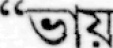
“ভায়
